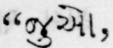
"જુઓ,
